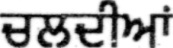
ਚਲਦੀਆਂ
